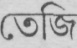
তেজি
